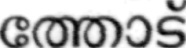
ത്തോട്
